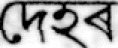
দেহৰ
